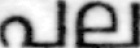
പല
